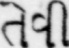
તેવી
